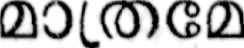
മാത്രമേ
